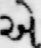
એ
